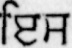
ਇਸ
